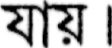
যায়।
